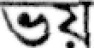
ভয়
